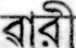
ৱারী
